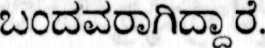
ಬಂದವರಾಗಿದ್ದಾರೆ.
